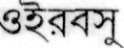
ওইরবসু
